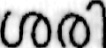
ശരി
